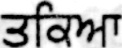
ਤਕਿਆ
